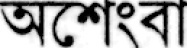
অশেংবা
